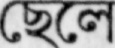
ছেলে
